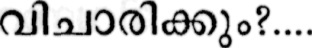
വിചാരിക്കും?....
